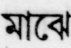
মাঝে
